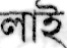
লাই
